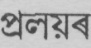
প্ৰলয়ৰ
